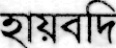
হায়বদি
